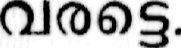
വരട്ടെ.
